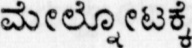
ಮೇಲ್ನೋಟಕ್ಕೆ
